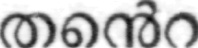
തന്റെ
